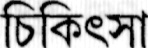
চিকিৎসা
